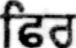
ਫਿਰ
